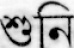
শুনি
